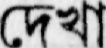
দেখা
